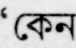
‘কেন
